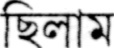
ছিলাম
